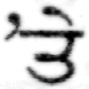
'ਤੇ
